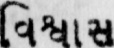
વિશ્વાસ
